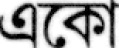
একো
